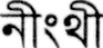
নীংথী
